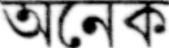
অনেক
